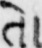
તો
